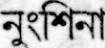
নুংশিনা
